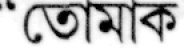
"তোমাক
